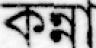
কন্না
